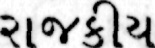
રાજકીય
